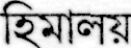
হিমালয়
